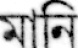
মানি
